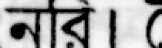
ফংজবা
